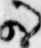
જે
